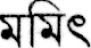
মমিৎ
